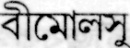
বীমোলসু
